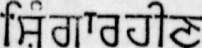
ਸ਼ਿੰਗਾਰਹੀਣ
